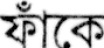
ফাঁকে
